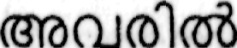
അവരില്‍
